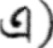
এ)
